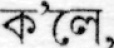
ক'লে,
